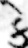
કે
